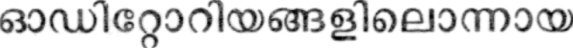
ഓഡിറ്റോറിയങ്ങളിലൊന്നായ
